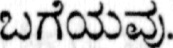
ಬಗೆಯವು.
